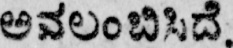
ಅವಲಂಬಿಸಿದೆ.
